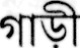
গাড়ী
